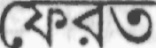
ফেরত
